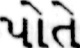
પોતે
